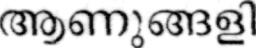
ആണുങ്ങളി
